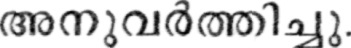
അനുവര്‍ത്തിച്ചു.
